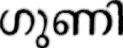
ഗുണി
